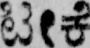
ಟೀಕೆ
